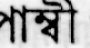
পাম্বী
